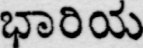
ಭಾರಿಯ
